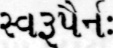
સ્વરૂપૈર્નઃ
